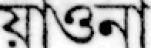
য়াওনা
